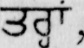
ਤਰ੍ਹਾਂ,
